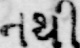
નથી
